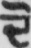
ਦੋ
